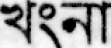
খংনা
